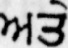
ਅਤੇ
